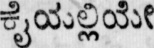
ಕೈಯಲ್ಲಿಯೇ
